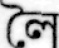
লৈ
